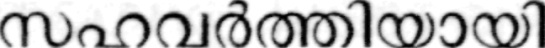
സഹവര്‍ത്തിയായി
